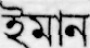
ইমান
